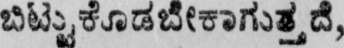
ಬಿಟ್ಟುಕೊಡಬೇಕಾಗುತ್ತದೆ,
